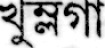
খুম্লগা
